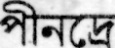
পীনদ্রে
